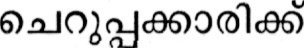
ചെറുപ്പക്കാരിക്ക്
